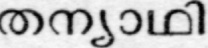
തന്യാഥി
